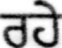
ਰਹੇ
